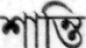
শান্তি
